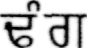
ਢੰਗ
